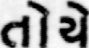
તોયે
